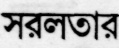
সরলতার
